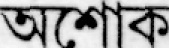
অশোক
